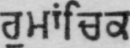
ਰੁਮਾਂਚਿਕ
